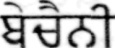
ਬੇਚੈਨੀ
